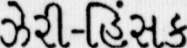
ઝેરી-હિંસક
